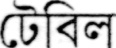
টেবিল
